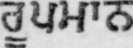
ਰੂਪਮਾਨ
